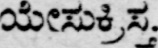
ಯೇಸುಕ್ರಿಸ್ತ.
